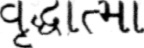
વૃદ્ધાત્મા
